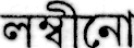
লম্বীনো
